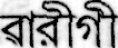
ৱারীগী
